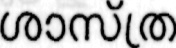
ശാസ്ത്ര
